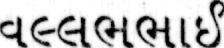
વલ્લભભાઈ
